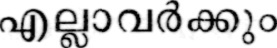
എല്ലാവര്‍ക്കും
